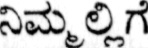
ನಿಮ್ಮಲ್ಲಿಗೆ
